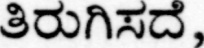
ತಿರುಗಿಸದೆ,
